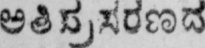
ಅತಿಪ್ರಸರಣದ
